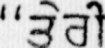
''ਤੇਰੀ
